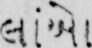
લાંબો
